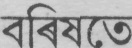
বৰিষতে
